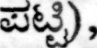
ಪಟ್ಟಿ),
